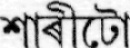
শাৰীটো
